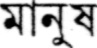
মানুষ
